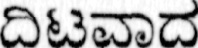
ದಿಟವಾದ
